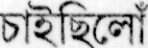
চাইছিলোঁ
